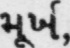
મૂર્ખ,
